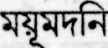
ময়ূমদনি
